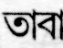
তাবা
